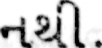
નથી.
